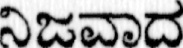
ನಿಜವಾದ
